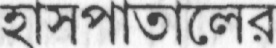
হাসপাতালের
